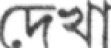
দেখা
